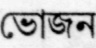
ভোজন
